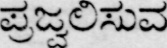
ಪ್ರಜ್ಜಲಿಸುವ
